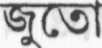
জুতো
